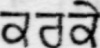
ਕਰਕੇ
